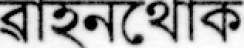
ৱাহনথোক
